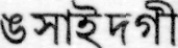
ঙসাইদগী
